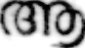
ആ
